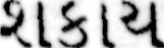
શકાય
